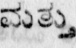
ಮತ್ತು
